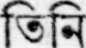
তিনি
